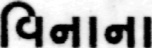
વિનાના
